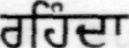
ਰਹਿੰਦਾ
